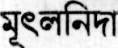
মূৎলনিদা
